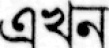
এখন
